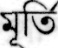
মূর্তি
